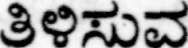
ತಿಳಿಸುವ
